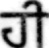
ਹੀ
